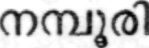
നമ്പൂരി
